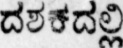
ದಶಕದಲ್ಲಿ
